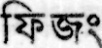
ফিজং
